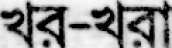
খর-খরা
